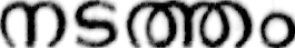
നടത്തം
